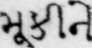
મૂકીને
